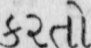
કરતો
